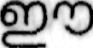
ഈ
